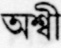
অশ্বী
